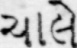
ચાલે
